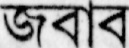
জবাব
